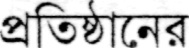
প্রতিষ্ঠানের
